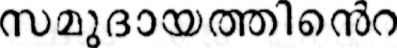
സമുദായത്തിന്റെ
